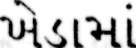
ખેડામાં
